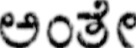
ಅಂತೇ
